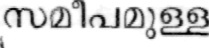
സമീപമുള്ള
